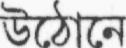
উঠোনে
